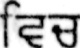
ਵਿਚ
